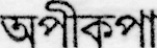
অপীকপা
